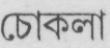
চোকলা
